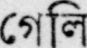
গেলি
